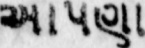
આપણા
